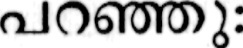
പറഞ്ഞു:
